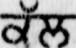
ਕੱਲ
